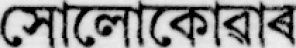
সোলোকোৱাৰ
